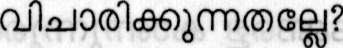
വിചാരിക്കുന്നതല്ലേ?
